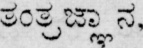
ತಂತ್ರಜ್ಞಾನ,
